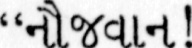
"નૌજવાન!
